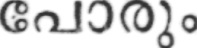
പോരും
